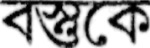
বস্তুকে
